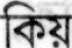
কিয়
